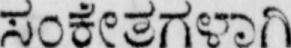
ಸಂಕೇತಗಳಾಗಿ
